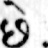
છે.
